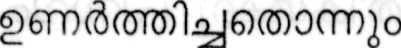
ഉണര്‍ത്തിച്ചതൊന്നും
